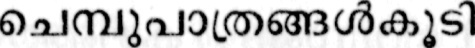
ചെമ്പുപാത്രങ്ങള്‍കൂടി
